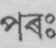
পৰঃ
